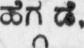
ಹೆಗ್ಗಡೆ,
